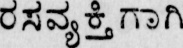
ರಸವ್ಯಕ್ತಿಗಾಗಿ
